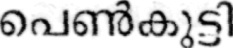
പെണ്‍കുട്ടി
